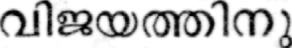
വിജയത്തിനു
